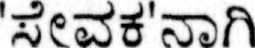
‘ಸೇವಕ’ನಾಗಿ
